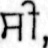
ਸੀ,
